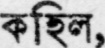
কহিল,
